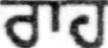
ਰਾਹ
